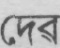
দেৱ
